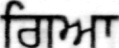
ਗਿਆ
